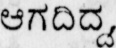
ಆಗದಿದ್ದ,
